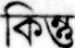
কিন্তু
